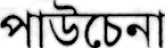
পাউচেনা
